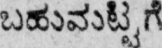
ಬಹುಮಟ್ಟಿಗೆ
